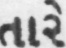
તારે
